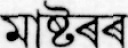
মাষ্টৰৰ
